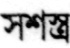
সশস্ত্র
